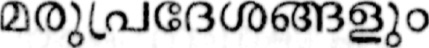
മരുപ്രദേശങ്ങളും
